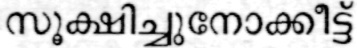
സൂക്ഷിച്ചുനോക്കീട്ട്
